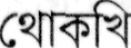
থোকখি
